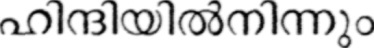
ഹിന്ദിയില്‍നിന്നും
